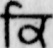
ਕਿ
